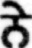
ਨੇ
